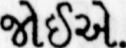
જોઈએ.
